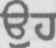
ਉਹ
